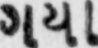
ગયા
